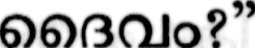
ദൈവം?”
